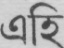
এহি
